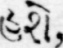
હશે,
